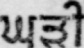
ਘੜੀ
